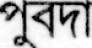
পুবদা
